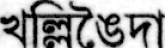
খল্লিঙৈদা
